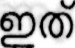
ഇത്
